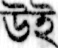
উই
